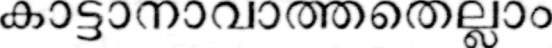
കാട്ടാനാവാത്തതെല്ലാം
